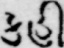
કહી
